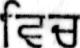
ਵਿਚ
